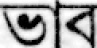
ভাব
